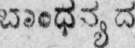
ಬಾಂಧವ್ಯದ
